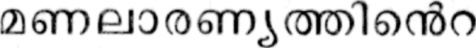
മണലാരണ്യത്തിന്റെ
